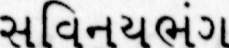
સવિનયભંગ
